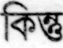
কিন্তু
